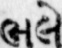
ભલે
